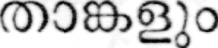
താങ്കളും
